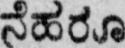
ನೆಹರೂ
